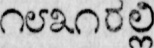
೧೮೩೧ರಲ್ಲಿ
